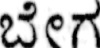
ಬೇಗ
